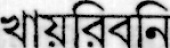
খায়রিবনি
